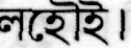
লৈহৌই
